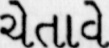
ચેતાવે
